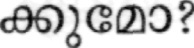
ക്കുമോ?
